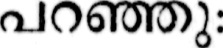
പറഞ്ഞു:
